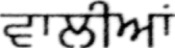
ਵਾਲੀਆਂ
